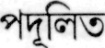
পদূলিত
